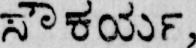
ಸೌಕರ್ಯ,
